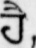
ਹੈ,
